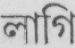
লাগি
